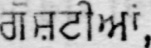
ਗੋਸ਼ਟੀਆਂ,
